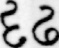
ર્દઢ
